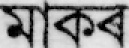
মাকৰ
